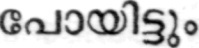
പോയിട്ടും
